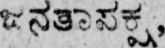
ಜನತಾಪಕ್ಷ,
